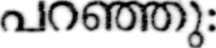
പറഞ്ഞു:
